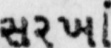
સરખાં
